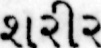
શરીર
